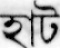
হাট
